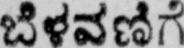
ಬೆಳವಣಿಗೆ
